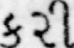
કરી
